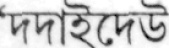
'দদাইদেউ
